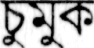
চুমুক
